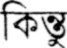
কিন্তু
